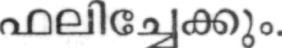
ഫലിച്ചേക്കും.
